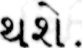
થશે.
